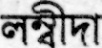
লম্বীদা
